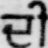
ਦੀ
